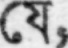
যে,
